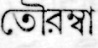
তৌরম্বা
